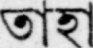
তাহা
